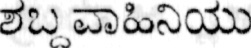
ಶಬ್ದವಾಹಿನಿಯು
